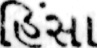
હિંસા
